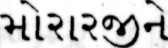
મોરારજીને
